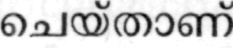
ചെയ്താണ്
